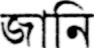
জানি
